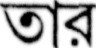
তার
